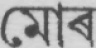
মোৰ
